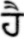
ਹੈ
